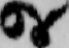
જ
